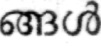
ങ്ങള്‍
